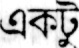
একটু
